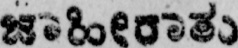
ಜಾಹೀರಾತು
